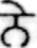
ਨੇ
